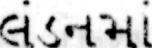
લંડનમાં
